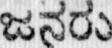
ಜನರು
